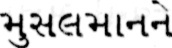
મુસલમાનને
